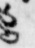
હું
